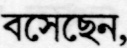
বসেছেন,
